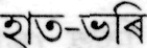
হাত-ভৰি
